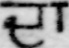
ਦਾ
